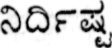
ನಿರ್ದಿಷ್ಟ
